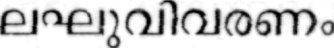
ലഘുവിവരണം
